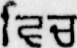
ਵਿਚ
